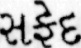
સફેદ
